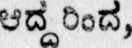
ಆದ್ದರಿಂದ,
